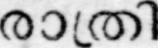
രാത്രി
